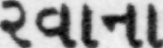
રવાના
